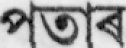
পতাৰ
